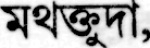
মথক্তুদা,
